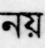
নয়
